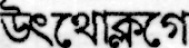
উৎথোক্লগে
